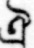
ঐ
